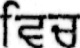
ਵਿਚ
